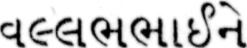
વલ્લભભાઈને
